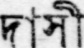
দাসী
